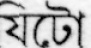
যিটো
